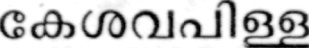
കേശവപിള്ള
